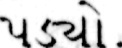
પડ્યો.
